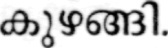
കുഴങ്ങി.
